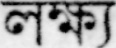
লক্ষ্য
